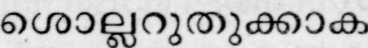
ശൊല്ലറുതുക്കാക
